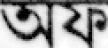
অফ
